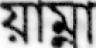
য়াম্না
